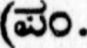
(ಪ೦.
